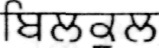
ਬਿਲਕੁਲ
